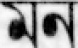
মন
